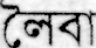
লৈবা
